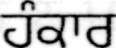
ਹੰਕਾਰ
